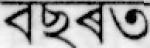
বছৰত
